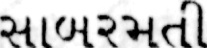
સાબરમતી
